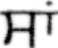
ਸਾਂ
